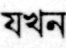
যখন
